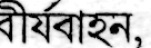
বীর্যবাহন,
